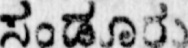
ಸಂಡೂರು
